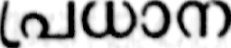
പ്രധാന
